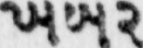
ખબર
